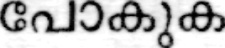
പോകുക
